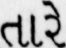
તારે
